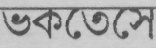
ভকতেসে
